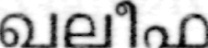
ഖലീഫ
